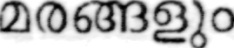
മരങ്ങളും
